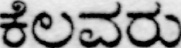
ಕೆಲವರು
